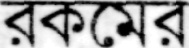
রকমের
